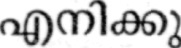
എനിക്കു
